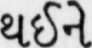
થઈને
